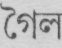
গৈল
